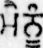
ਮੈਨੂੰ
